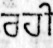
ਰਹੀ
